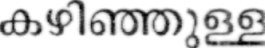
കഴിഞ്ഞുള്ള
